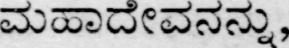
ಮಹಾದೇವನನ್ನು,
